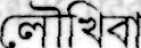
লৌখিবা
